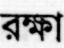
রক্ষা
